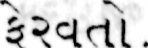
ફેરવતો.
